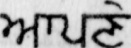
ਆਪਣੇ
